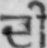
ਦੀ
